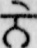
ਨੇ
